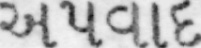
અપવાદ
